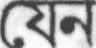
যেন
